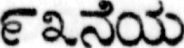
೯೩ನೆಯ
